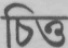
চিত্ত
